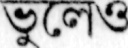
ভুলেও
